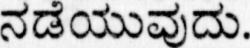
ನಡೆಯುವುದು.
